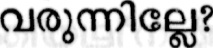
വരുന്നില്ലേ?
